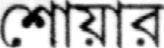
শোয়ার
